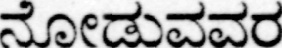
ನೋಡುವವರ
